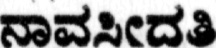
ನಾವಸೀದತಿ
